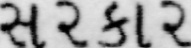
સરકાર
